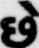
છે
